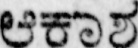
ಆಕಾಶ
